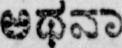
ಅಥವಾ
